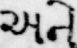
અને
